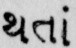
થતાં
